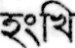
হংখি
